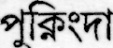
পুক্নিংদা
